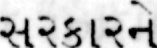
સરકારને
